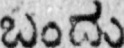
ಬಂದು
